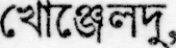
খোঞ্জেলদু,
